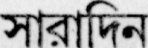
সারাদিন
